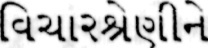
વિચારશ્રેણીને
